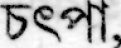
চৎপা,
